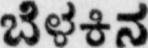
ಬೆಳಕಿನ
